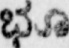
ಭೂ
